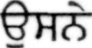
ਉਸਨੇ
